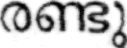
രണ്ടു
